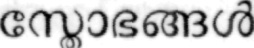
സ്തോഭങ്ങള്‍
